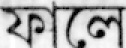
ফালে
